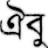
ঐবু
